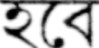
হবে
